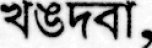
খঙদবা,
